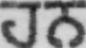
ਹਨ
